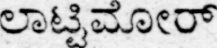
ಲಾಟ್ಟಿಮೋರ್
